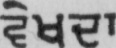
ਵੇਖਦਾ
